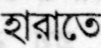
হারাতে
